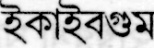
ইকাইবগুম
